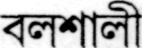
বলশালী
